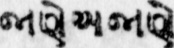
જાણેઅજાણે
